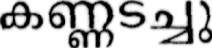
കണ്ണടച്ചു
